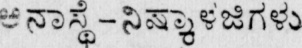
ಅನಾಸ್ಥೆ-ನಿಷ್ಕಾಳಜಿಗಳು
